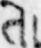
તો
